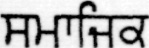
ਸਮਾਜਿਕ
